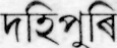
দহিপুৰি
